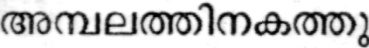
അമ്പലത്തിനകത്തു
